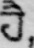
ਹੈ,
